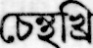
চেন্থখ্রি
